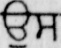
ਉਸ
